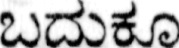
ಬದುಕೂ
